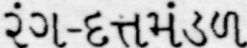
રંગ-દત્તમંડળ
